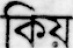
কিয়
